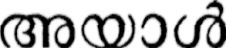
അയാള്‍
